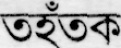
তহঁতক
